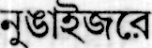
নুঙাইজরে
